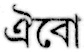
ঐবো
